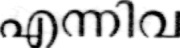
എന്നിവ
